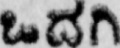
ಒದಗಿ
